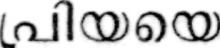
പ്രിയയെ
